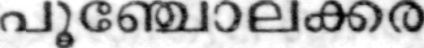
പൂഞ്ചോലക്കര
